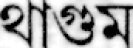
থাগুম
